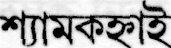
শ্যামকহ্ণাই
